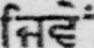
ਜਿਵੇਂ
